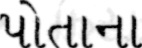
પોતાના
